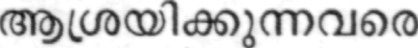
ആശ്രയിക്കുന്നവരെ
